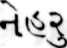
નેહરુ
